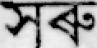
সৰু
